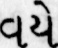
વયે
